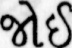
જોઈ
